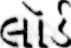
લૉર્ડ
